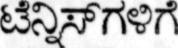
ಟೆನ್ನಿಸ್‌ಗಳಿಗೆ
